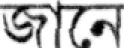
জানে
